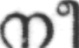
നീ
